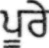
ਪੂਰੇ
